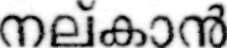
നല്കാന്‍
